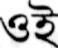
ওই
